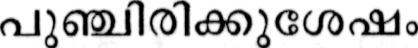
പുഞ്ചിരിക്കുശേഷം
